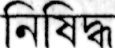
নিষিদ্ধ
